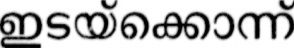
ഇടയ്ക്കൊന്ന്
